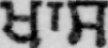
ਖਾਸ
